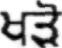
ਖੜੋ
